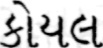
કોયલ
